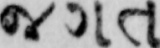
જગત
